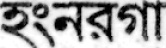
হংনরগা
